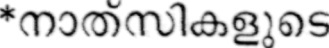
*നാത്സികളുടെ
